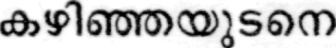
കഴിഞ്ഞയുടനെ
